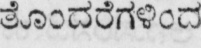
ತೊಂದರೆಗಳಿಂದ
